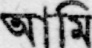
আমি
